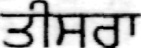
ਤੀਸਰਾ
